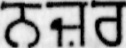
ਨਜ਼ਰ
